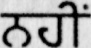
ਨਹੀਂ
